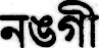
নঙগী
